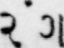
રંગ
